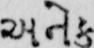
અનેક
